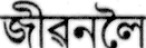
জীৱনলৈ
